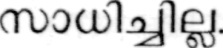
സാധിച്ചില്ല.
